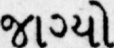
જાગ્યો
